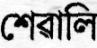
শেৱালি
